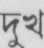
দুখ
